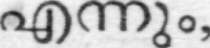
എന്നും,
